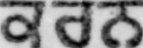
ਕਰਨ
